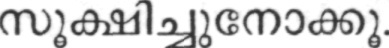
സൂക്ഷിച്ചുനോക്കൂ.
